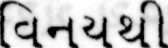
વિનયથી
